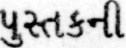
પુસ્તકની
